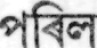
পৰিল
